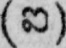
(ಐ)
